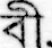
বী.
